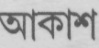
আকাশ
